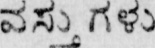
ವಸ್ತುಗಳು
